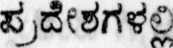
ಪ್ರದೇಶಗಳಲ್ಲಿ
